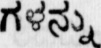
ಗಳನ್ನು
